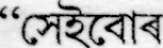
"সেইবোৰ
